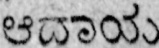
ಆದಾಯ
